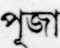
পূজা
